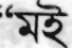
"মই
